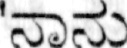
ನಾನು
